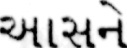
આસને
